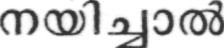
നയിച്ചാല്‍
